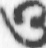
ও
